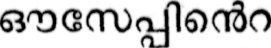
ഔസേപ്പിന്റെ
